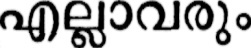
എല്ലാവരും
